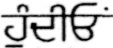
ਹੁੰਦੀਓਂ
